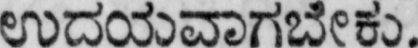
ಉದಯವಾಗಬೇಕು.
